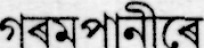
গৰমপানীৰে
